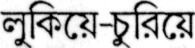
লুকিয়ে-চুরিয়ে
